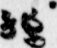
કહું
